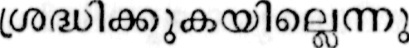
ശ്രദ്ധിക്കുകയില്ലെന്നു
